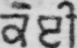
ਕੋਈ
